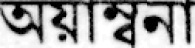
অয়ান্বনা
